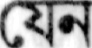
যেন
